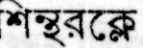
শিন্থরক্লে
